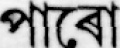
পাৰো
